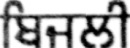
ਬਿਜਲੀ
